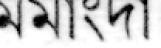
মমাংদা
